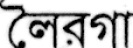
লৈরগা
